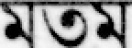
মতম
